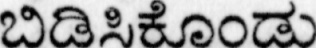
ಬಿಡಿಸಿಕೊಂಡು
